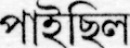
পাইছিল
